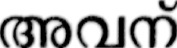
അവന്
